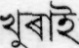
খুৰাই
